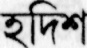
হদিশ
